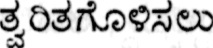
ತ್ವರಿತಗೊಳಿಸಲು
